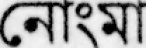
নোংমা
